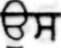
ਉਸ
